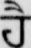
ਹੈ
